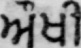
ਔਖੀ
